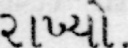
રાખ્યો.
